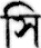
সি
